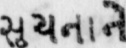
સુચનાને
